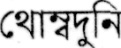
থোম্বদুনি
